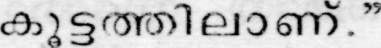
കൂട്ടത്തിലാണ്.''
